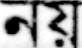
নয়
